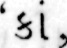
'કાં,
